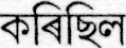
কৰিছিল
